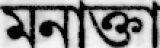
মনাক্তা
